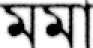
মমা
